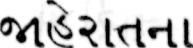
જાહેરાતના
